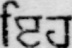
ਇਹ
